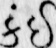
કંઈ
